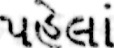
પહેલાં
